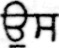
ਉਸ
